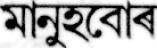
মানুহবোৰ
